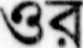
ওর
